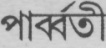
পাৰ্ব্বতী
